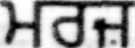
ਮਰਜ਼
